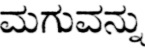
ಮಗುವನ್ನು
